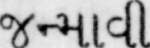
જન્માવી
